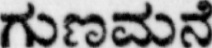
ಗುಣಮನೆ
